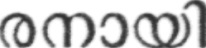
രനായി
